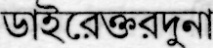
ডাইরেক্তরদুনা
